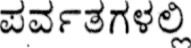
ಪರ್ವತಗಳಲ್ಲಿ
